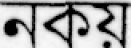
নকয়
